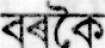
বৰকৈ
